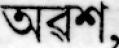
অৱশ,
